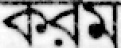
করম
